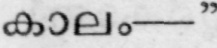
കാലം-"
